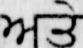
ਅਤੇ
